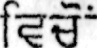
ਵਿਚੋਂ
